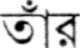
তাঁর
